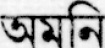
অমনি
